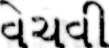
વેચવી
